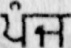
ਪੰਜ
